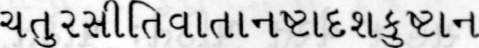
ચતુરસીતિવાતાનષ્ટાદશકુષ્ટાન
